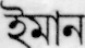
ইমান
